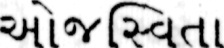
ઓજસ્વિતા
